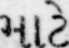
માટે
